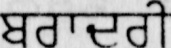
ਬਰਾਦਰੀ
